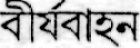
বীৰ্যবাহন
